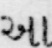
આ
